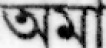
অমা
